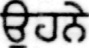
ਉਹਨੇ
